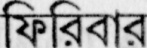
ফিরিবার
